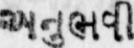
અનુભવી
